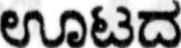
ಊಟದ
